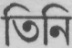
তিনি
